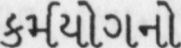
કર્મયોગનો
